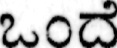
ಒಂದೆ
